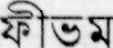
ফীভম
